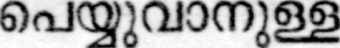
പെയ്യുവാനുള്ള
